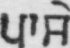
ਪਾਸੇ
